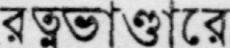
রত্নভাণ্ডারে
